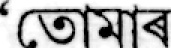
'তোমাৰ
